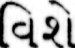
વિશે
